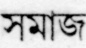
সমাজ
